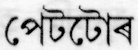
পেটটোৰ
